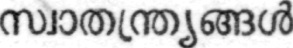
സ്വാതന്ത്ര്യങ്ങള്‍
